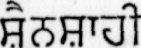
ਸ਼ੈਨਸ਼ਾਹੀ
